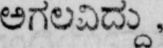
ಅಗಲವಿದ್ದು,
